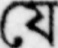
যে
